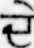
ਦੇ
